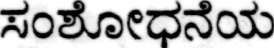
ಸಂಶೋಧನೆಯ
